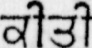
ਕੀਤੀ
